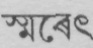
স্মৰেৎ
